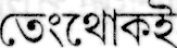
তেংথোকই
